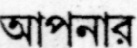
আপনার
